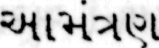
આમંત્રણ
